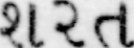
શરત
